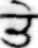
ਤੇ
